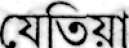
যেতিয়া
